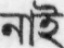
নাই
